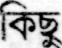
কিছু
